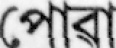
পোৱা
